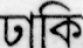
ঢাকি
